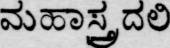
ಮಹಾಸ್ತ್ರದಲಿ
